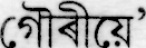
গৌৰীয়ে'
